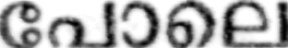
പോലെ
